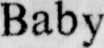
Baby
